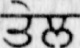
ਤੇਲ
